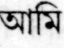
আমি
